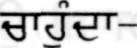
ਚਾਹੁੰਦਾ-
